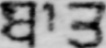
ਬਾਤ
